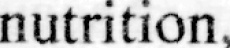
nutrition,
